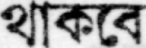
থাকবে
